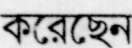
করেছেন
